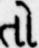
તો
